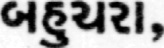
બહુચરા,
